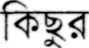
কিছুর
